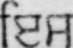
ਇਸ
